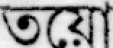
তয়ো
